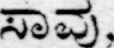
ಸಾವು,
